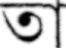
তা
